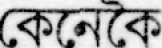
কেনেকৈ
